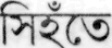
সিহঁতে
